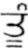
ਤੂੰ
